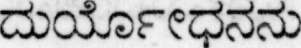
ದುರ್ಯೋಧನನು
